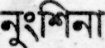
নুংশিনা
